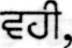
ਵਹੀ,
